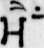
ਮੈਂ
